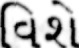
વિશે
